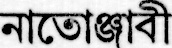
নাতোঞ্জাবী
